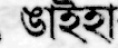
লেপ্তুনা
